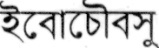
ইবোচৌবসু
